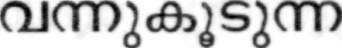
വന്നുകൂടുന്ന
